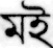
মই
